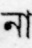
না
